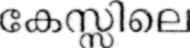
കേസ്സിലെ
